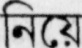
নিয়ে
